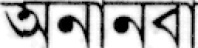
অনানবা
